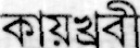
কায়খ্রবী
